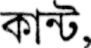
কান্ট,
